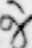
જે
